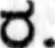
ರ.
